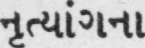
નૃત્યાંગના
